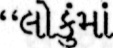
"લોકુંમાં
